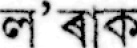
ল'ৰাক
